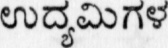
ಉದ್ಯಮಿಗಳ
